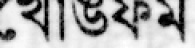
খোঙফম
